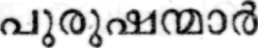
പുരുഷന്മാര്‍
